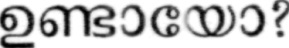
ഉണ്ടായോ?
